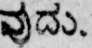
ವುದು.
